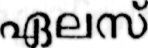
ഏലസ്
